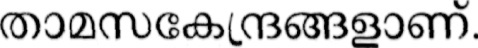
താമസകേന്ദ്രങ്ങളാണ്.
